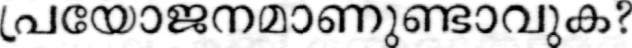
പ്രയോജനമാണുണ്ടാവുക?
